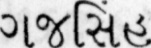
ગજસિંહ
